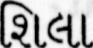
શિલા
